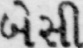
બેસી
